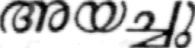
അയച്ചു
